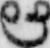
ಆ
